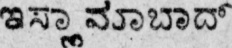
ಇಸ್ಲಾಮಾಬಾದ್
